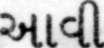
આવી
